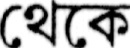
থেকে
